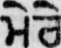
ਮੇਰੇ
